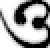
ও
